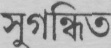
সুগন্ধিত
